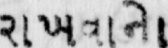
રાખવાનો
